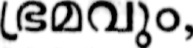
ഭ്രമവും,
